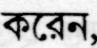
করেন,
